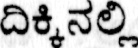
ದಿಕ್ಕಿನಲ್ಲಿ
